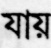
যায়
